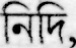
নিদি,
